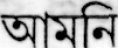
আমনি
